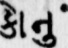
કોનું
